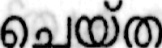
ചെയ്ത
